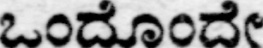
ಒಂದೊಂದೇ
